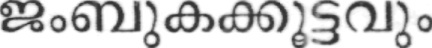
ജംബുകക്കൂട്ടവും
